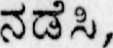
ನಡೆಸಿ,
